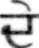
ਦੇ
